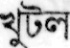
খুটল
